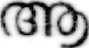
ആ
